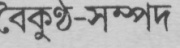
বৈকুণ্ঠ-সম্পদ
